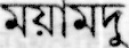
ময়ামদু
